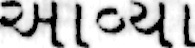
આવ્યા
